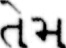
તેમ
